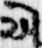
એ
